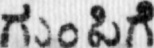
ಗುಂಪಿಗೆ
